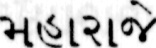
મહારાજે
